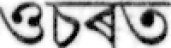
ওচৰত
